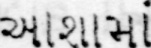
આશામાં
